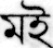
মই
